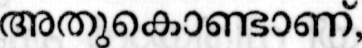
അതുകൊണ്ടാണ്,
